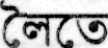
লৈতে
